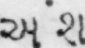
અંશ
